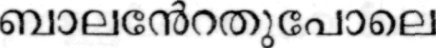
ബാലന്റേതുപോലെ
